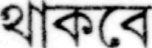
থাকবে
